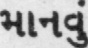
માનવું
